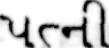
પત્ની
